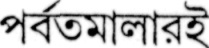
পর্বতমালারই
